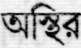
অস্থির
